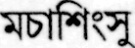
মচাশিংসু
